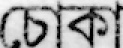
চোকা
